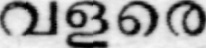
വളരെ
